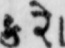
કરો
